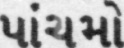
પાંચમો
